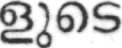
ളുടെ
